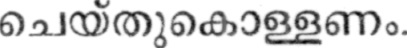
ചെയ്തുകൊള്ളണം.
